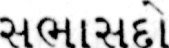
સભાસદો
